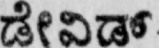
ಡೇವಿಡ್
